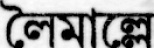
লৈমাল্লে
